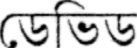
ডেভিড
